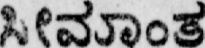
ಸೀಮಾಂತ
